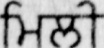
ਮਿਲੀ
